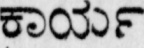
ಕಾರ್ಯ
